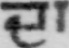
ਦਾ
